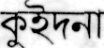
কুইদনা
